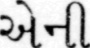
એની
